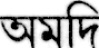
অমদি
